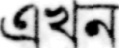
এখন
